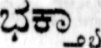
ಭಕ್ತ್ಯಾ
